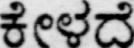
ಕೇಳದೆ
